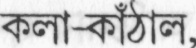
কলা-কাঁঠাল,
